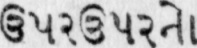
ઉપરઉપરનો
